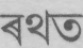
ৰথত
